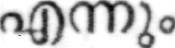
എന്നും
